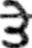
ਤੇ
